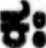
ಕಃ
